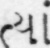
ત્યાં
